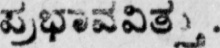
ಪ್ರಭಾವವಿತ್ತು.
